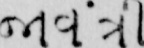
જાયંત્રી
